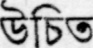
উচিত
